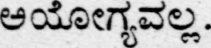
ಅಯೋಗ್ಯವಲ್ಲ.
